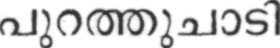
പുറത്തുചാടി
